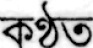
কণ্ঠত
